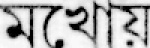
মখোয়
